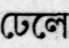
ঢেলে
